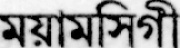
ময়ামসিগী
